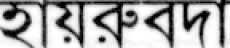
হায়রুবদা
